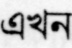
এখন
